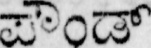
ಪೌಂಡ್
